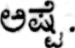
ಅಷ್ಟೆ.
